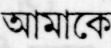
আমাকে
